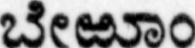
ಬೇಱಾಂ
